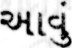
આવું
